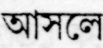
আসলে
